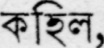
কহিল,
